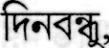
দিনবন্ধু,
